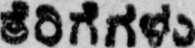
ತೆರಿಗೆಗಳು
